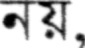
নয়,
